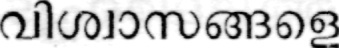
വിശ്വാസങ്ങളെ
